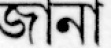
জানা
